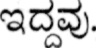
ಇದ್ದವು.
